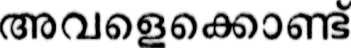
അവളെക്കൊണ്ട്
